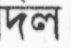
দিল
